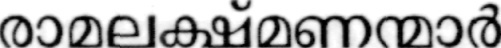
രാമലക്ഷ്മണന്മാര്‍
